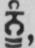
ਨੂੰ,
